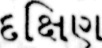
દક્ષિણ
